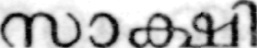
സാക്ഷി
